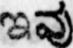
ಇವು
